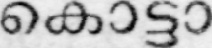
കൊട്ടാ
